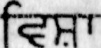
ਵਿਸ਼ਾ
